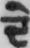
ਦੇ
